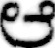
ಆ
